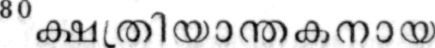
80ക്ഷത്രിയാന്തകനായ
